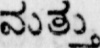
ಮತ್ತು
